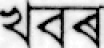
খবৰ
